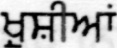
ਖੁਸ਼ੀਆਂ
